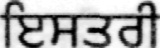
ਇਸਤਰੀ
